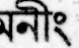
মনীং
